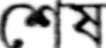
শেষ
